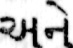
અને
